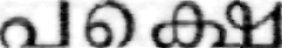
പക്ഷെ
